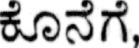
ಕೊನೆಗೆ,
